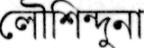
লৌশিন্দুনা
